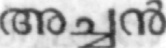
അച്ചന്‍
